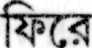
ফিরে
